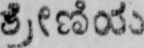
ಶ್ರೇಣಿಯ
